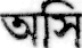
অসি
